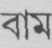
বাম
